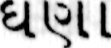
ઘણા
